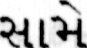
સામે
